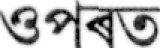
ওপৰত
